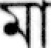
মা
